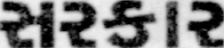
સરકાર
